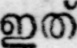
ഇത്
